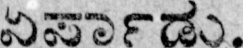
ಏರ್ಪಾಡು.
